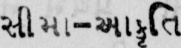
સીમા-આકૃતિ
